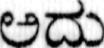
ಅದು
